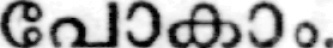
പോകാം.
